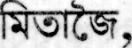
মিতাজৈ,
